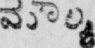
ಮೌಲ್ಯ
